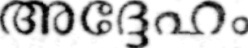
അദ്ദേഹം
